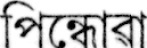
পিন্ধোৱা
